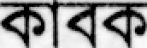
কাবক
